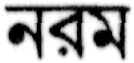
নরম
